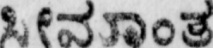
ಸೀಮಾಂತ
